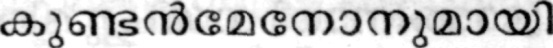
കുണ്ടന്‍മേനോനുമായി
